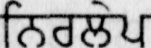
ਨਿਰਲੇਪ
